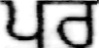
ਪਰ
